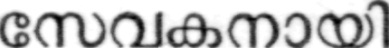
സേവകനായി
